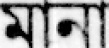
মানা
